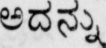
ಅದನ್ನು
